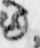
છે,
